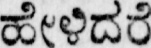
ಹೇಳಿದರೆ
